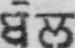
ਬੋਲ
